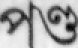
পণ্ড
